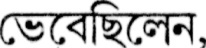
ভেবেছিলেন,
